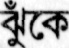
ঝুঁকে
